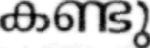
കണ്ടു
